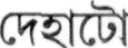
দেহাটো
